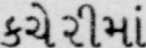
કચેરીમાં
